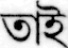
তাই
